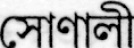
সোণালী
